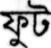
ফুট
